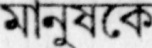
মানুষকে
